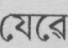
যেৱে
